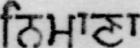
ਨਿਮਾਣਾ
